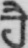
ਹੈ
